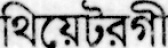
থিয়েটরগী
